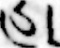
હા
